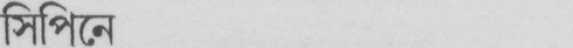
সিপিনে
